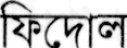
ফিদোল
